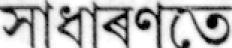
সাধাৰণতে
